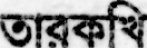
তারকখি
